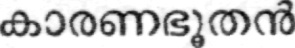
കാരണഭൂതന്‍
